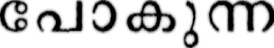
പോകുന്ന
